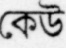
কেউ
